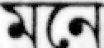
মনে
